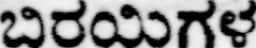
ಬಿರಯಿಗಳ
